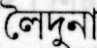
লৈদুনা
